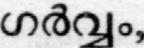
ഗര്‍വ്വം,
